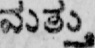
ಮತ್ತು
